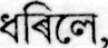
ধৰিলে,
